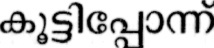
കൂട്ടിപ്പോന്ന്
